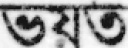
ভয়ত
